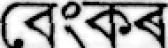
বেংকৰ
